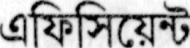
এফিসিয়েন্ট
